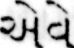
એવે
